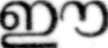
ഈ
